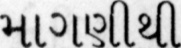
માગણીથી
